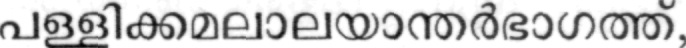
പള്ളിക്കമലാലയാന്തര്‍ഭാഗത്ത്,
